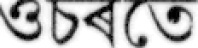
ওচৰতে
